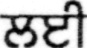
ਲਈ
